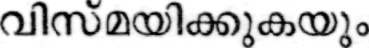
വിസ്മയിക്കുകയും
